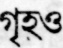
গৃহও
